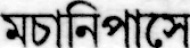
মচানিপাসে
